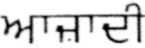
ਆਜ਼ਾਦੀ
